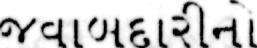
જવાબદારીનો
